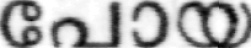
പോയ
